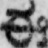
ಈ
